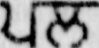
ਪਲ
